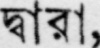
দ্বারা,
